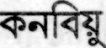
কনবিয়ু
